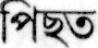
পিছত
